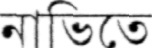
নাভিতে
